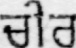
ਚੀਰ
